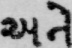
અને
